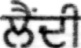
ਲੈਂਦੀ
